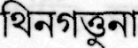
থিনগৎত্তুনা
